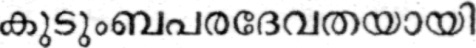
കുടുംബപരദേവതയായി
